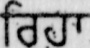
ਰਿਹਾ
